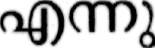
എന്നു
